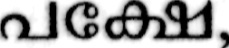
പക്ഷേ,
